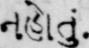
નહોતું.
